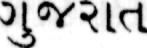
ગુજરાત
